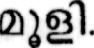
മൂളി.
